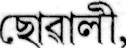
ছোৱালী,
